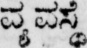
ವ್ಯವಸ್ಥೆ
